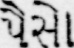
પૈસો
